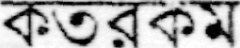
কতরকম
